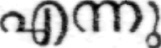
എന്നു
